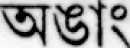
অঙাং
